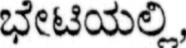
ಭೇಟಿಯಲ್ಲಿ,
